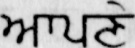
ਆਪਣੇ
